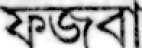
ফজবা
